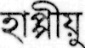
হাপ্পীয়ু
